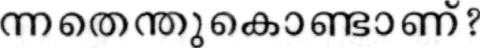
ന്നതെന്തുകൊണ്ടാണ്?
